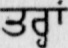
ਤਰ੍ਹਾਂ
